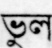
ভুল
